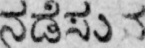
ನಡೆಸುವ
